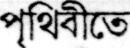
পৃথিবীতে
